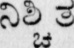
ನಿಶ್ಚಿತ
